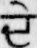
ਦੇ
